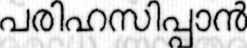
പരിഹസിപ്പാന്‍
